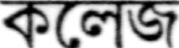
কলেজ
